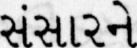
સંસારને
